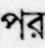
পর
